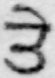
ਤੇ
